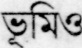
ভূমিও
